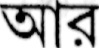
আর
